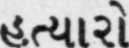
હત્યારો
